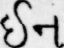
ઈન
